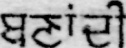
ਬਣਾਂਦੀ
